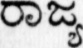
ರಾಜ್ಯ
